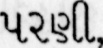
પરણી,
